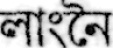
লাংনৈ
